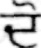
ਦੋ
